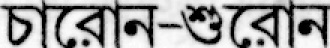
চারোল-শুরোন
